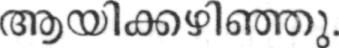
ആയിക്കഴിഞ്ഞു.
